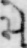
સામે
